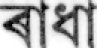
ৰাধা
